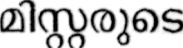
മിസ്റ്റരുടെ
